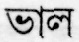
ভাল
